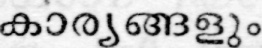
കാര്യങ്ങളും
